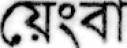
য়েংবা
